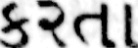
કરતા
